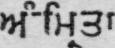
ਅੰਮ੍ਰਿਤਾ
